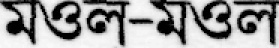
মওল-মওল
